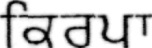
ਕਿਰਪਾ
